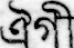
ঐগী
